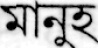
মানুহ
